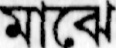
মাঝে
